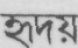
হৃদয়
